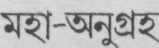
মহা-অনুগ্ৰহ
